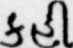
કહી
